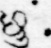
છું.
